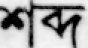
শব্দ
